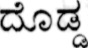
ದೊಡ್ಡ
